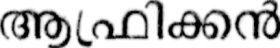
ആഫ്രിക്കന്‍
